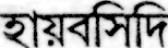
হায়বসিদি
